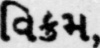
વિક્રમ,
